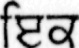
ਇਕ
